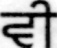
ਵੀ
